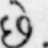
છે.
